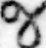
જ
